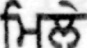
ਮਿਲੇ
